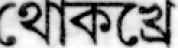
থোকখ্রে
